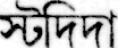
স্টদিদা
